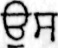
ਉਸ
